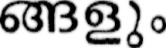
ങ്ങളും
